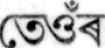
তেওঁৰ
